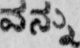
ವನ್ನು
